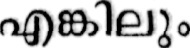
എങ്കിലും
